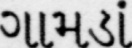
ગામડાં
